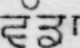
ਵੱਡਾ
